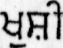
ਖੁਸ਼ੀ
